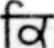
ਕਿ
